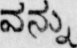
ವನ್ನು
